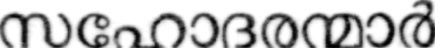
സഹോദരന്മാര്‍
